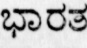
ಭಾರತ
